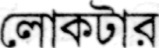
লোকটার
